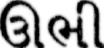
ઊભી
